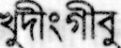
খুদীংগীবু
